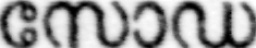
സോഡ
